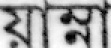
য়াম্না
